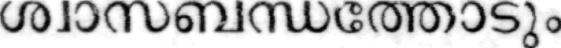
ശ്വാസബന്ധത്തോടും
